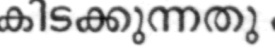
കിടക്കുന്നതു
